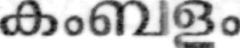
കംബളം
